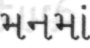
મનમાં
